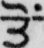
ਤੋਂ
